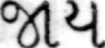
જાય
